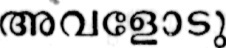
അവളോടു
